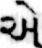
એ
